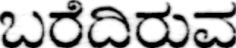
ಬರೆದಿರುವ
